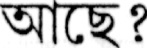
আছে?
